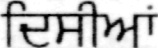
ਦਿਸੀਆਂ
